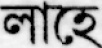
লাহে
